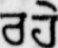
ਰਹੇ
